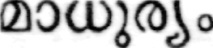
മാധുര്യം
